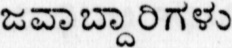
ಜವಾಬ್ದಾರಿಗಳು
